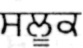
ਸਲੂਕ
